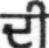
ਦੀ
